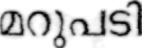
മറുപടി
